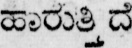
ಹಾರುತ್ತಿದೆ
